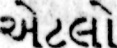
એટલો
